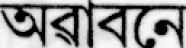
অৱাবনে
